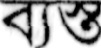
ব্যস্ত
